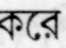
করে
